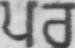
ਪਰ
